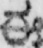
ಈ
